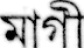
মাগী
